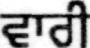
ਵਾਰੀ
